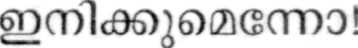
ഇനിക്കുമെന്നോ!
